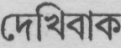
দেখিবাক
